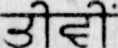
ਤੀਵੀਂ
